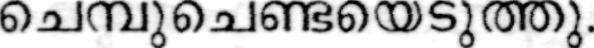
ചെമ്പുചെണ്ടയെടുത്തു.
